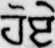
ਹੋਏ
